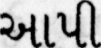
આપી
